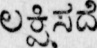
ಲಕ್ಷಿಸದೆ
